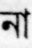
না
